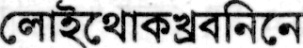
লোইথোকখ্রবনিনে
